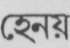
হেনয়
